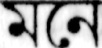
মনে
